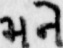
મને
